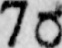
7ರ
